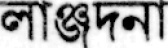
লাঞ্জদনা
